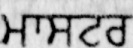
ਮਾਸਟਰ
